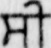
ਸੀ
